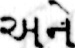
અને
